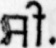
ਸੀ.
